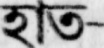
হাত-
